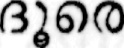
ദൂരെ
